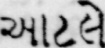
આટલે
